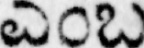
ಎಂಬ
